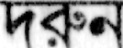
দরুন
